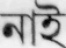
নাই
